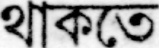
থাকতে
